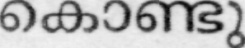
കൊണ്ടു
